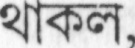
থাকল,
